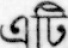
এটি
